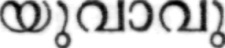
യുവാവു
